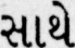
સાથે
